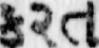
કરત
